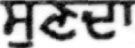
ਸੁਣਦਾ
